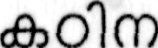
കഠിന
